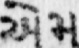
એમ
